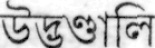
উদ্ভণ্ডালি
